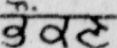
ਭੌਂਕਣ
